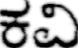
ಕವಿ
